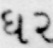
ધર
